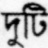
দুটি
